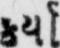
કર્યા
